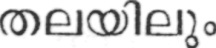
തലയിലും
